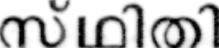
സ്ഥിതി
